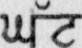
ਘੱਟ
